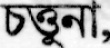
চত্তুনা,
